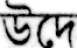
উদে
